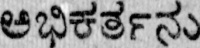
ಅಭಿಕರ್ತನು
